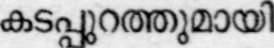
കടപ്പുറത്തുമായി
